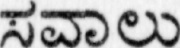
ಸವಾಲು
